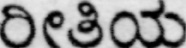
ರೀತಿಯ
